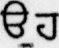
ਉਹ
